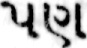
પણ
